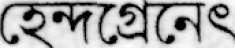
হেন্দগ্রেনেৎ
